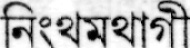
নিংথমথাগী
